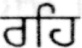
ਰਹਿ
